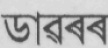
ডাৱৰৰ
